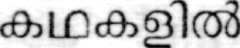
കഥകളില്‍
